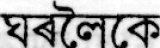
ঘৰলৈকে
